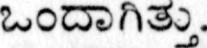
ಒಂದಾಗಿತ್ತು.
